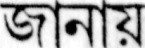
জানায়
